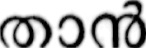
താന്‍
